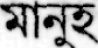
মানুহ
